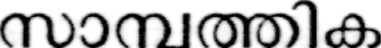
സാമ്പത്തിക
